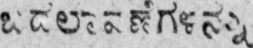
ಬದಲಾವಣೆಗಳನ್ನು
